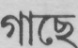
গাছে
